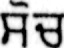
ਸੋਚ
